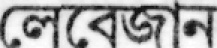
লেবেজান
